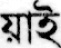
য়াই
